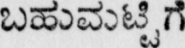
ಬಹುಮಟ್ಟಿಗೆ
